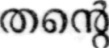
തന്റെ
